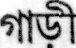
গাড়ী
